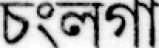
চংলগা
